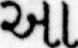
આ
